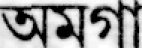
অমগা
